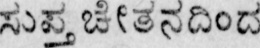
ಸುಪ್ತಚೇತನದಿಂದ
